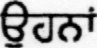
ਉਹਨਾਂ
